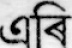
এৰি
